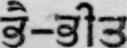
ਭੈ-ਭੀਤ
